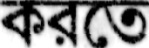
করতে
